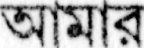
আমার
